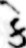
કે
